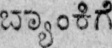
ಬ್ಯಾಂಕಿಗೆ
